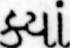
ક્યાં
